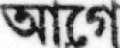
আগে
